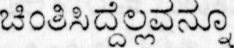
ಚಿಂತಿಸಿದ್ದೆಲ್ಲವನ್ನೂ
